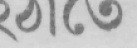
হঠাতে
